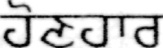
ਹੋਣਹਾਰ
